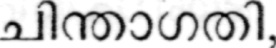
ചിന്താഗതി,
